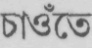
চাওঁতে
